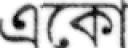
একো
